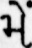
મેં
